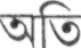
অতি
